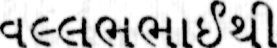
વલ્લભભાઈથી
